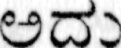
ಅದು
